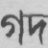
গদ
